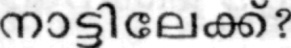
നാട്ടിലേക്ക്?
